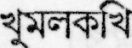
খুমলকখি
